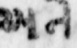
અને
